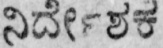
ನಿರ್ದೇಶಕ
